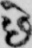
છે
